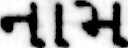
નામ
